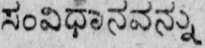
ಸಂವಿಧಾನವನ್ನು
